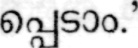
പ്പെടാം.’
